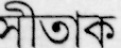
সীতাক
